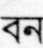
বন
